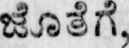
ಜೊತೆಗೆ,
